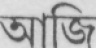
আজি
